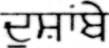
ਦੁਸ਼ਾਂਬੇ
